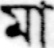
মা
